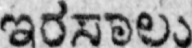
ಇರಸಾಲು
